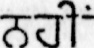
ਨਹੀਂ
